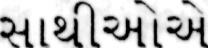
સાથીઓએ
